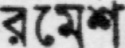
রমেশ
